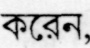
করেন,
